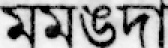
মমঙদা
